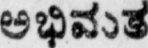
ಅಭಿಮತ
